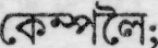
কেম্পলৈ;
